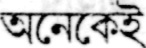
অনেকেই
